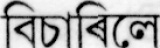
বিচাৰিলে
